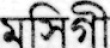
মসিগী
